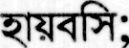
হায়বসি;
